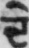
ਦੇ
